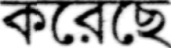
করেছে
